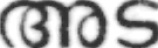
അട
